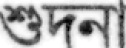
শুদনা
